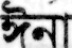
ঈনা
